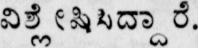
ವಿಶ್ಲೇಷಿಸಿದ್ದಾರೆ.
